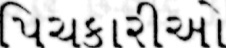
પિચકારીઓ
